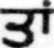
ਤਾਂ
